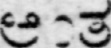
ಅಂತ
